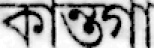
কান্তগা
